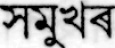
সমুখৰ
